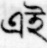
এই
